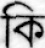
কি
